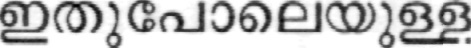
ഇതുപോലെയുള്ള
